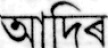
আদিৰ
